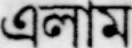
এলাম
